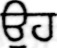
ਉਹ
